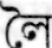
লৈ
